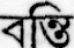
বন্তি
